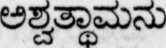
ಅಶ್ವತ್ಥಾಮನು
